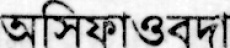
অসিফাওবদা
